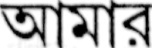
আমার
